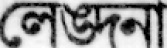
লেঙদনা
